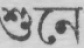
শুনে
